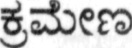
ಕ್ರಮೇಣ
